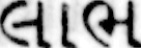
લાભ
